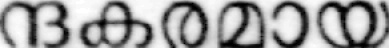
ന്ദകരമായ
